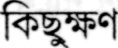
কিছুক্ষণ
